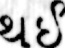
થઈ
